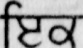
ਇਕ
